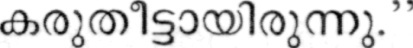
കരുതീട്ടായിരുന്നു."
